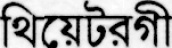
থিয়েটরগী
